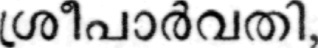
ശ്രീപാര്‍വതി,
